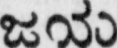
ಜಯ
